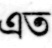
এত
